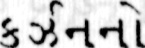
કર્ઝનનો
